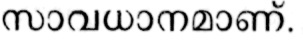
സാവധാനമാണ്.
